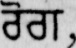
ਰੋਗ,
